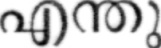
എന്തു
